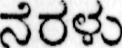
ನೆರಳು
